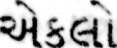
એકલો
